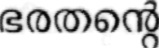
ഭരതന്റെ
